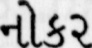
નોકર
